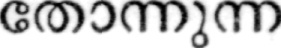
തോന്നുന്ന
